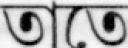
তাতে
